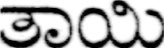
ತಾಯಿ
